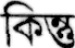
কিন্তু
